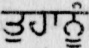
ਤੁਹਾਨੂੰ
